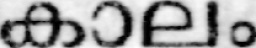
കാലം
